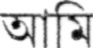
আমি
